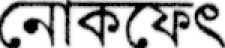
নোকফেৎ
